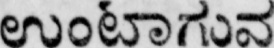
ಉಂಟಾಗುವ
